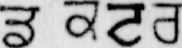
ਡਾਕਟਰ
